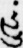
હું
